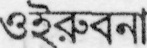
ওইরুবনা
